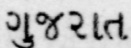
ગુજરાત
